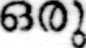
ഒരു
